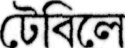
টেবিলে
